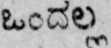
ಒಂದಲ್ಲ
